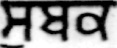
ਸੁਬਕ
